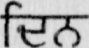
ਦਿਨ
